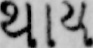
થાય
